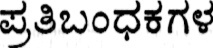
ಪ್ರತಿಬಂಧಕಗಳ
